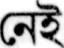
নেই
